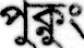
পুক্নুং
